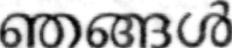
ഞങ്ങള്‍
